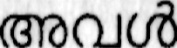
അവള്‍
